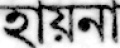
হায়না
